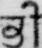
ਭੀ
